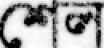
শেল
